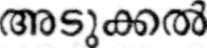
അടുക്കല്‍
